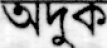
অদুক
